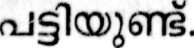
പട്ടിയുണ്ട്.
